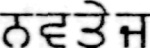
ਨਵਤੇਜ
